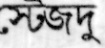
স্টেজদু
